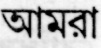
আমরা
